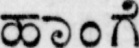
ಹಾಂಗೆ
